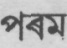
পৰম
